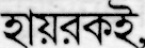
হায়রকই,
